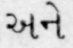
અને
